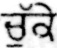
ਚੁੱਕੇ
